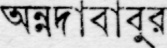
অন্নদাবাবুর
